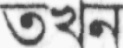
তখন
